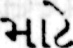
માટે
